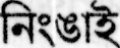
নিংঙাই
